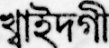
খ্বাইদগী
